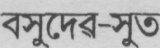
বসুদেৱ-সুত
